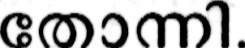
തോന്നി.
